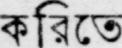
করিতে
